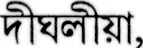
দীঘলীয়া,
